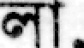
লা.
